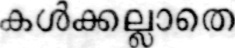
കള്‍ക്കല്ലാതെ
